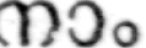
നാം
